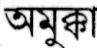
অমুক্কা
